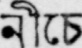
নীচে
